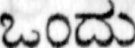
ಒಂದು
